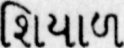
શિયાળ
